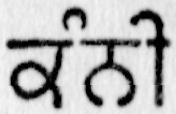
ਕੰਨੀ
